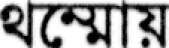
থম্মোয়
